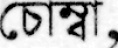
চোম্বা,
